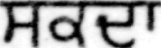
ਸਕਦਾ
